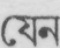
যেন
